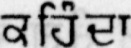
ਕਹਿੰਦਾ
